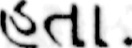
હતા.
